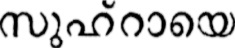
സുഹ്റായെ
